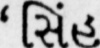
'સિંહ
